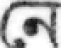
নে
